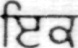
ਇਕ
